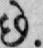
છે.
